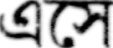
এসে
